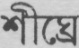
শীঘ্ৰে
